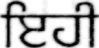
ਇਹੀ
